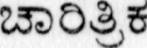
ಚಾರಿತ್ರಿಕ
